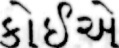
કોઈએ
